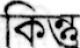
কিন্তু
